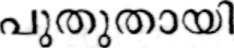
പുതുതായി
